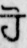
ਹੋ
